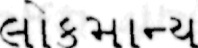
લોકમાન્ય
